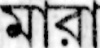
মারা
